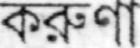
করুণা
